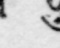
તમે
